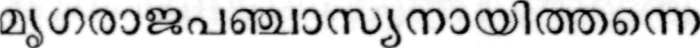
മൃഗരാജപഞ്ചാസ്യനായിത്തന്നെ
